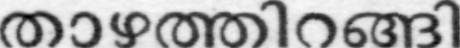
താഴത്തിറങ്ങി
